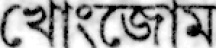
খোংজোম
